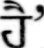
ਹੈ'
